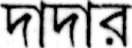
দাদার
